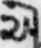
એ
